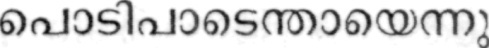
പൊടിപാടെന്തായെന്നു
